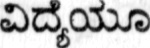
ವಿದ್ಯೆಯೂ
